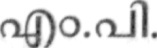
എം.പി.
